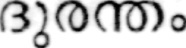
ദുരന്തം
